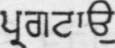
ਪ੍ਰਗਟਾਉ
